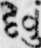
દેવું
